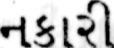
નકારી
